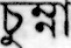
চুম্না
